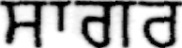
ਸਾਗਰ
